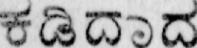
ಕಡಿದಾದ
